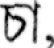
চা,
